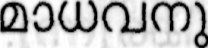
മാധവനു
